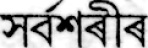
সর্বশৰীৰ
